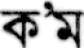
ক'ম
